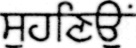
ਸੁਹਣਿਉਂ
